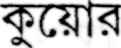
কুয়োর
